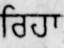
ਰਿਹਾ
